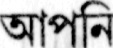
আপনি
